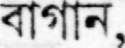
বাগান,
